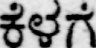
ಕೆಳಗೆ
